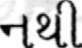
નથી
